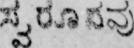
ಸ್ವರೂಪವು
